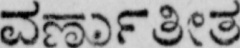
ವರ್ಣಾತೀತ
